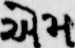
એમ
